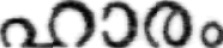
ഹാരം
